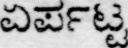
ಏರ್ಪಟ್ಟ
